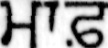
ਮਾਫ਼
